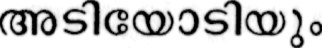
അടിയോടിയും
